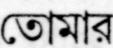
তোমার
